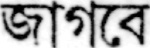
জাগবে
